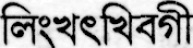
লিংখৎখিবগী
